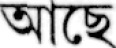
আছে
